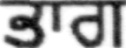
ਭਾਗ
